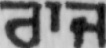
ਰਾਜ
